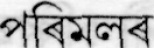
পৰিমলৰ
